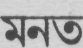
মনত
